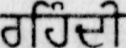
ਰਹਿੰਦੀ
